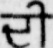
ਦੀ
